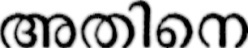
അതിനെ
